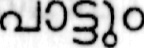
പാട്ടും
